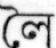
লৈ
